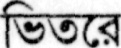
ভিতরে
